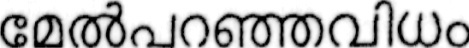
മേല്‍പറഞ്ഞവിധം
